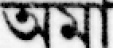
অমা
